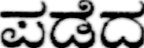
ಪಡೆದ
